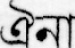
ঐনা
